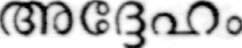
അദ്ദേഹം
